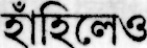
হাঁহিলেও
